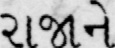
રાજાને
